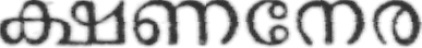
ക്ഷണനേര
